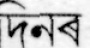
দিনৰ
